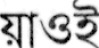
য়াওই
